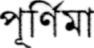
পূর্ণিমা
